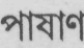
পাষাণ
